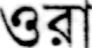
ওরা
